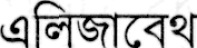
এলিজাবেথ
